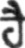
ਹੈ
